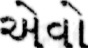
એવો
